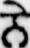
ਨੇ
